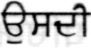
ਉਸਦੀ
